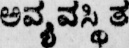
ಅವ್ಯವಸ್ಥಿತ
